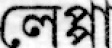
লেপ্পা
